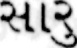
સારુ
